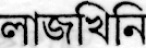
লাজখিনি
